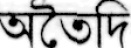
অতৈদি
